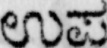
ಉಪ
